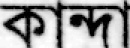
কান্দা
